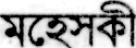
মহেসকী
